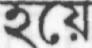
হয়ে
